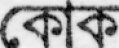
কোক
